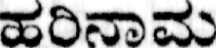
ಹರಿನಾಮ
